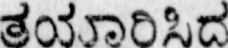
ತಯಾರಿಸಿದ
